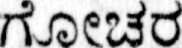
ಗೋಚರ
